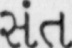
સંત
